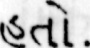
હતો.
